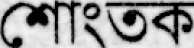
শোংতক
